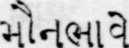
મૌનભાવે
